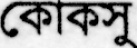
কোকসু
